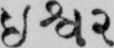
ઈશ્વર
